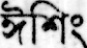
ঈশিং
